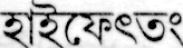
হাইফেৎতং
